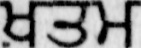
ਖ਼ਤਮ
